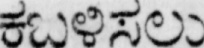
ಕಬಳಿಸಲು
